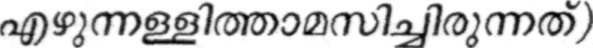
എഴുന്നള്ളിത്താമസിച്ചിരുന്നത്)
